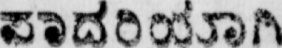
ಪಾದರಿಯಾಗಿ
